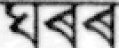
ঘৰৰ
